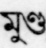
মুণ্ড
